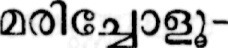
മരിച്ചോളൂ-
